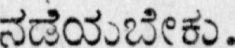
ನಡೆಯಬೇಕು.
